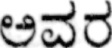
ಅವರ
